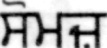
ਸੋਮਜ਼
